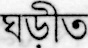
ঘড়ীত
